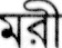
মরী
